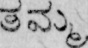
ತಮ್ಮ
